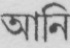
আনি
